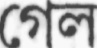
গেল
